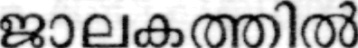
ജാലകത്തില്‍
